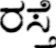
ರಸ್ತೆ
